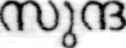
സുന്ദ
